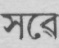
সৱে
